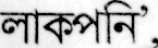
লাকপনি’,
